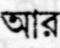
আর
